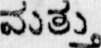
ಮತ್ತು
